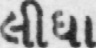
લીધા
